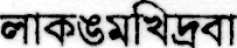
লাকঙমখিদ্রবা
